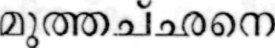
മുത്തച്ഛനെ
